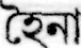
হৈনা
